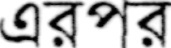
এরপর
